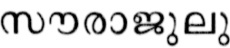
സൌരാജുലു
